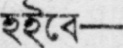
হইবে—
